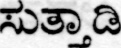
ಸುತ್ತಾಡಿ
